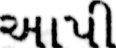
આપી
